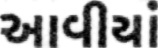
આવીયાં
